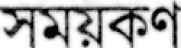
সময়কণ
